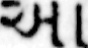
આ
